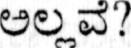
ಅಲ್ಲವೆ?
